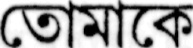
তোমাকে
